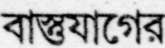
বাস্তুযাগের
